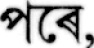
পৰে,
